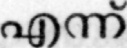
എന്ന്
